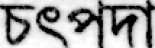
চৎপদা
